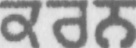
ਕਰਨ
